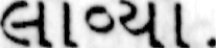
લાવ્યા.
